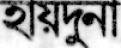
হায়দুনা
